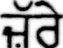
ਜ਼ੱਰੇ
